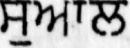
ਸੁਆਲ
